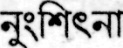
নুংশিৎনা
